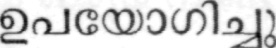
ഉപയോഗിച്ചു
